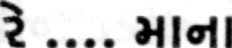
નોરતા
